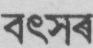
বৎসৰ
